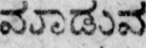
ಮಾಡುವ
